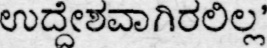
ಉದ್ದೇಶವಾಗಿರಲಿಲ್ಲ’
